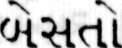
બેસતો
